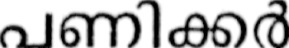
പണിക്കര്‍
